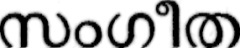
സംഗീത
